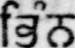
ਭਿੰਨ
